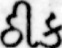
ઠીક
